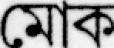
মোক
